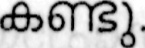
കണ്ടു.
